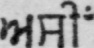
ਅਸੀਂ
